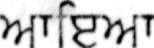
ਆਇਆ
